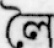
লৈ
